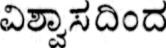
ವಿಶ್ವಾಸದಿಂದ
